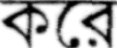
করে
